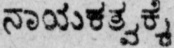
ನಾಯಕತ್ವಕ್ಕೆ
